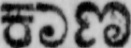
ಕಾಣ
